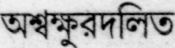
অশ্বক্ষুরদলিত
